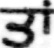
ਤਾਂ
